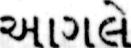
આગલે
